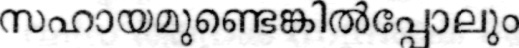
സഹായമുണ്ടെങ്കില്‍പ്പോലും
